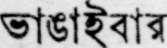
ভাঙাইবার
